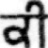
ਕੀ
